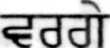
ਵਰਗੇ
